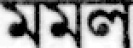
মমল
